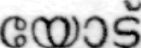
യോട്
